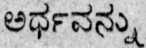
ಅರ್ಧವನ್ನು
